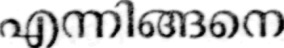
എന്നിങ്ങനെ
